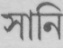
সানি
